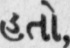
હતો,
